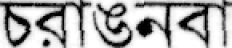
চরাঙনবা
